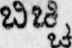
ಬಿಚ್ಚಿ
